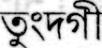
তুংদগী
